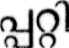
പ്പറ്റി
